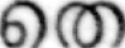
തെ
